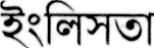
ইংলিসতা
